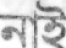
নাই
